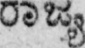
ರಾಜ್ಯ
